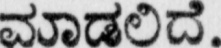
ಮಾಡಲಿದೆ.
